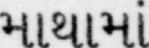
માથામાં
